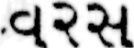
વરસ
